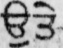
ਉਤੇ
